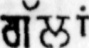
ਗੱਲਾਂ
